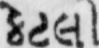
કેટલી
